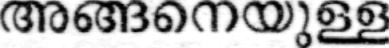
അങ്ങനെയുള്ള
